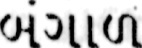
બંગાળ
